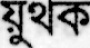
য়ুথক
